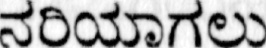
ನರಿಯಾಗಲು
